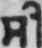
ਸੀ
